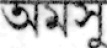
অমসু
